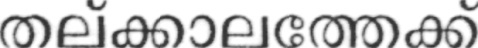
തല്ക്കാലത്തേക്ക്
